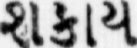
શકાય
